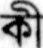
কী
